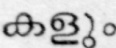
കളും
